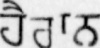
ਹੈਰਾਨ
